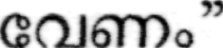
വേണം”
